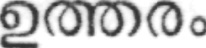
ഉത്തരം
